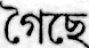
গৈছে
